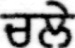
ਚਲੇ
